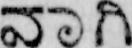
ವಾಗಿ
